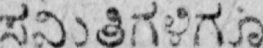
ಸಮಿತಿಗಳಿಗೂ
